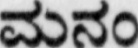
ಮನಂ
